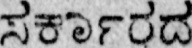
ಸರ್ಕಾರದ
